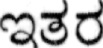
ಇತರ
